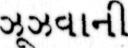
ઝૂઝવાની
